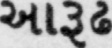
આરૂઢ
